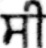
ਸੀ
